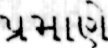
પ્રમાણે
